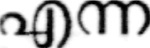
എന്ന
